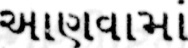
આણવામાં
